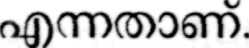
എന്നതാണ്.
